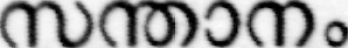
സന്താനം
